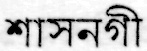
শাসনগী
